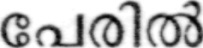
പേരില്‍
